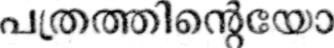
പത്രത്തിന്റെയോ
